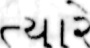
ત્યારે
